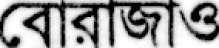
বোরাজাও
